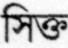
সিক্ত
